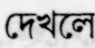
দেখলে
